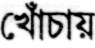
খোঁচায়
